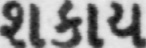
શકાય
